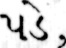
પડે,
